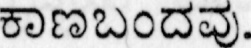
ಕಾಣಬಂದವು.
